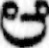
ಆ
